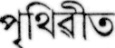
পৃথিৱীত
